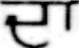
ਦਾ
